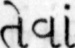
તેવાં
